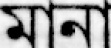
মানা
